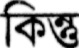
কিন্তু
